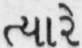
ત્યારે
